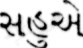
સહુએ
